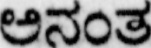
ಅನಂತ
